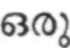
ഒരു
